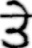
ਤੇ
